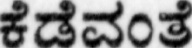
ಕೆಡೆವಂತೆ
